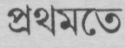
প্ৰথমতে
